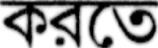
করতে
